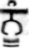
ਨੂੰ
